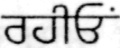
ਰਹੀਓਂ
